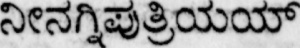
ನೀನಗ್ನಿಪುತ್ರಿಯಯ್
